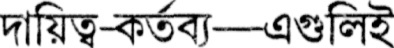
দায়িত্ব-কর্তব্য-এগুলিই
